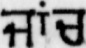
ਜਾਂਚ
